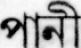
পানী
